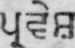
ਪ੍ਰਵੇਸ਼
